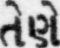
તેણે
